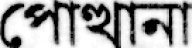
পোত্থানা
